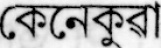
কেনেকুৱা
